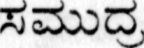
ಸಮುದ್ರ
